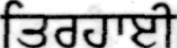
ਤਿਰਹਾਈ
